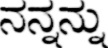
ನನ್ನನ್ನು
